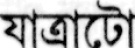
যাত্রাটো
